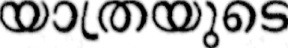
യാത്രയുടെ
